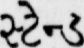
સ્ટેન્ડ
